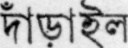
দাঁড়াইল
